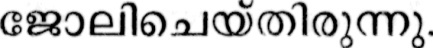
ജോലിചെയ്തിരുന്നു.
